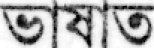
ভাষাত
